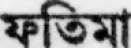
ফতিমা
